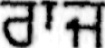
ਰਾਜ
